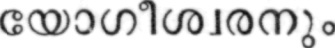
യോഗീശ്വരനും
